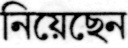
নিয়েছেন
